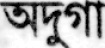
অদুগা
